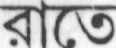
রাতে
